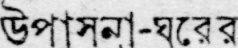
উপাসনা-ঘরের
